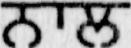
ਨਾਲ
